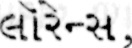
લૉરેન્સ,
